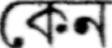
কেন
